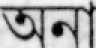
অনা
